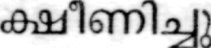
ക്ഷീണിച്ചു
